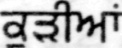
ਕੁੜੀਆਂ
